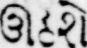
ઊઠશે
